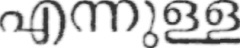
എന്നുള്ള
